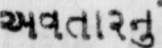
અવતારનું
